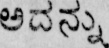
ಅದನ್ನು
